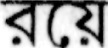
রয়ে
